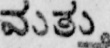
ಮತ್ತು
